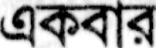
একবার
